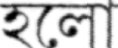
হলো
